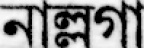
নাল্লগা
